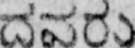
ದವರು
